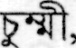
চু্ম্মী,
